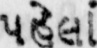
પહેલાં
